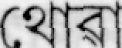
থোৱা
